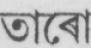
তাৰো
